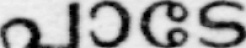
പാടേ
